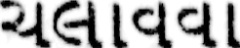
ચલાવવા
